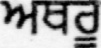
ਅਥਰੂ
